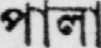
পালা
